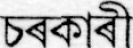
চৰকাৰী
